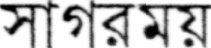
সাগরময়
